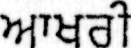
ਆਖਰੀ
